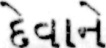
દેવાને
